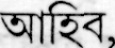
আহিব,
